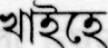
খাইহে
